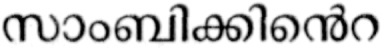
സാംബിക്കിന്റെ
